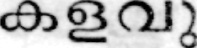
കളവു
